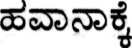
ಹವಾನಾಕ್ಕೆ
